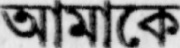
আমাকে
